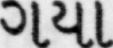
ગયા
